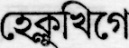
হেক্লুখিগে
